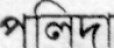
পলিদা
